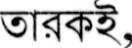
তারকই,
